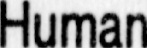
Human
